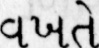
વખતે
